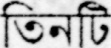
তিনটি
